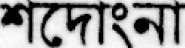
শদোংনা
